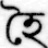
হৈ
